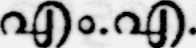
എം.എ.
